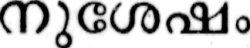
നുശേഷം
